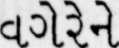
વગેરેને
